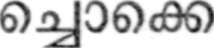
ച്ചൊക്കെ
